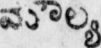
ಮೌಲ್ಯ
